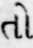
તો
